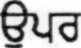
ਉਪਰ
